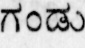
ಗಂಡು
